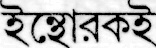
ইন্থোরকই
